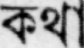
কথা
